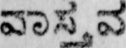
ವಾಸ್ತವ
